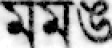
মমঙ
